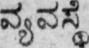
ವ್ಯವಸ್ಥೆ
